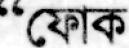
“ফোক
